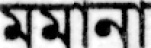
মমানা
